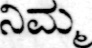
ನಿಮ್ಮ
